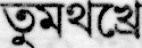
তুমথখ্রে
